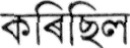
কৰিছিল
